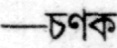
–চণক
